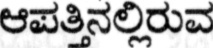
ಆಪತ್ತಿನಲ್ಲಿರುವ
